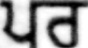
ਪਰ
